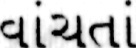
વાંચતાં
